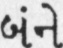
બંને
